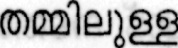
തമ്മിലുള്ള
